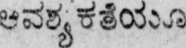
ಅವಶ್ಯಕತೆಯೂ
